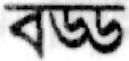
বড্ড
